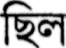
ছিল
